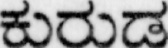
ಕುರುಡ
